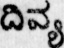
ದಿವ್ಯ
